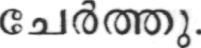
ചേര്‍ത്തു.
